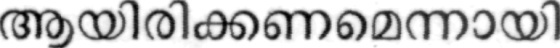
ആയിരിക്കണമെന്നായി
